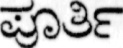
ಪೂರ್ತಿ
